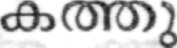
കത്തു
